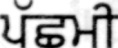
ਪੱਛਮੀ
